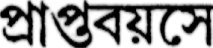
প্রাপ্তবয়সে
